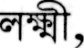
লক্ষ্মী,
